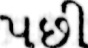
પછી
